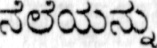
ನೆಲೆಯನ್ನು
